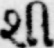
શી
